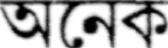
অনেক
